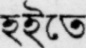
হইতে
